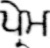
ਪ੍ਰੇਮ
